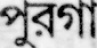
পুরগা
